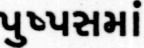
પુષ્પસમાં
